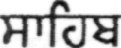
ਸਾਹਿਬ
